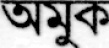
অমুক
